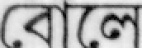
বোলে
